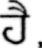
ਹੈ,
